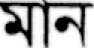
মান
